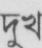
দুখ
